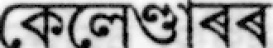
কেলেণ্ডাৰৰ
